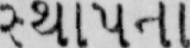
સ્થાપના
